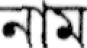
নাম
